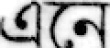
এনে
